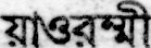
য়াওরম্মী
